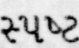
સ્પષ્ટ
